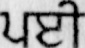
ਪਈ
